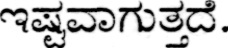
ಇಷ್ಟವಾಗುತ್ತದೆ.
